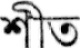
শীত
